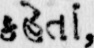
કહેતાં,
